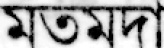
মতমদা
